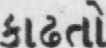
કાઢતો
